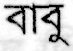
বাবু
